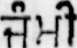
ਜੰਮੀ
